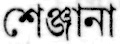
শেঞ্জানা
